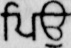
ਪਿਉ
